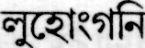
লুহোংগনি
